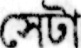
সেটা
